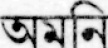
অমনি
